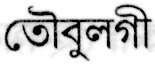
তৌবুলগী
